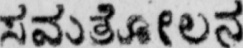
ಸಮತೋಲನ
